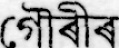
গৌৰীৰ
